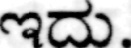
ಇದು.
